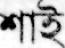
শাই
